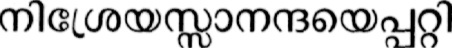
നിശ്രേയസ്സാനന്ദയെപ്പറ്റി
